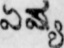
ಏಷ್ಯ
